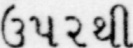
ઉપરથી
